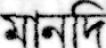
মানদি
